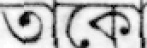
তাকো
